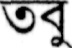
তবু
